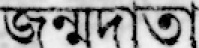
জন্মদাতা
